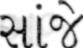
સાંજે
